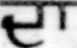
ਦਾ
